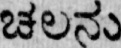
ಚಲನು
